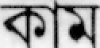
কাম
